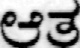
ಆತ
